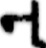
ન
